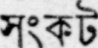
সংকট
